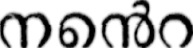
നന്റെ
